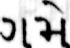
ગમે
